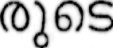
രുടെ
